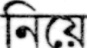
নিয়ে
